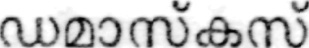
ഡമാസ്കസ്
